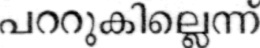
പററുകയില്ലെന്ന്
